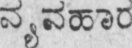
ವ್ಯವಹಾರ
